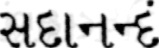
સદાનન્દં
